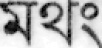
মথং
